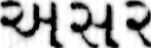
અસર
